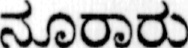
ನೂರಾರು
